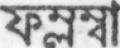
ফম্লম্বা
